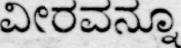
ವೀರವನ್ನೂ
